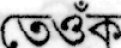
তেওঁক
